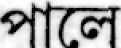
পালে
